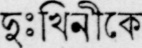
দুঃখিনীকে
